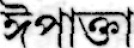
ঈপাক্তা
